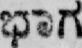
ಭಾಗ
